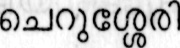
ചെറുശ്ശേരി
